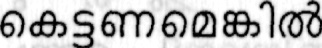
കെട്ടണമെങ്കില്‍
